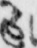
હો
